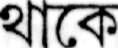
থাকে
